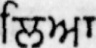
ਲਿਆ
